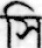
সি
